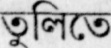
তুলিতে
